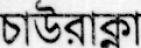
চাউরাক্না
